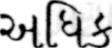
અધિક
